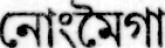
নোংমৈগা
